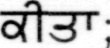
ਕੀਤਾ;
